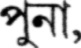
পুনা,
